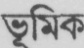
ভূমিক
